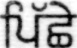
ਪਿੱਛੇ
